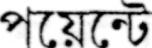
পয়েন্টে
